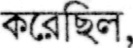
করেছিল,
